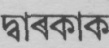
দ্বাৰকাক
